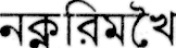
নক্নরিমখৈ
